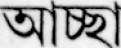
আচ্ছা
